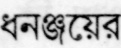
ধনঞ্জয়ের
